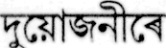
দুয়োজনীৰে
